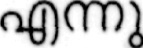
എന്നു
